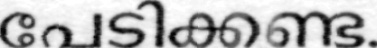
പേടിക്കണ്ട.
